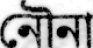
নৌনা
